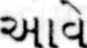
આવે
